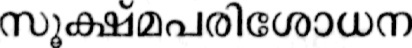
സൂക്ഷ്മപരിശോധന
